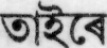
তাইৰে
